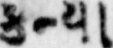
કન્યા
